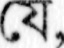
যে,
